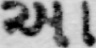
આ
